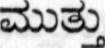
ಮುತ್ತು
